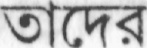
তাদের
